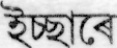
ইচ্ছাৰে
